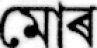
মোৰ
